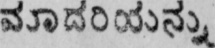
ಮಾದರಿಯನ್ನು
